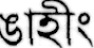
ঙাহীং
